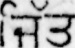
ਜਿੱਤ
